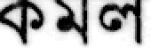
কমল
